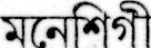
মনেশিগী
